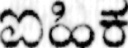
ಐಹಿಕ
